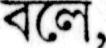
বলে,
